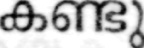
കണ്ടു
